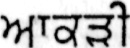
ਆਕੜੀ
